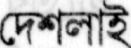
দেশলাই
